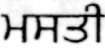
ਮਸਤੀ
